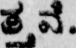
ತ್ತವೆ.
